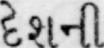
દેશની
